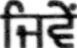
ਜਿਵੇਂ
